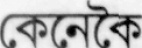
কেনেকৈ
